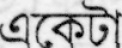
একেটা
